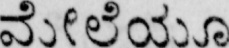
ಮೇಲೆಯೂ
